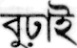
বুঢ়াই
